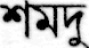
শমদু
